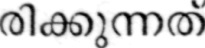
രിക്കുന്നത്
